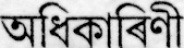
অধিকাৰিণী
